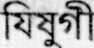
যিষুগী
